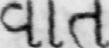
વાત
